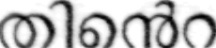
തിന്റെ
